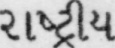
રાષ્ટ્રીય
